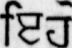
ਇਹੋ
